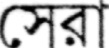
সেরা
